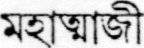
মহাত্মাজী
